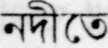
নদীতে
